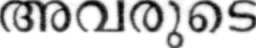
അവരുടെ
